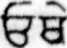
ਓਥੇ
